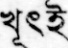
খুৎই
